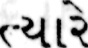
ત્યારે
